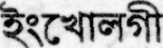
ইংখোলগী
